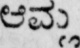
ಆಮ್ಲ
